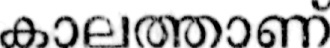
കാലത്താണ്
